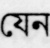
যেন
